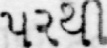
પરથી
